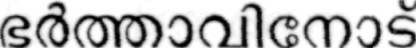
ഭര്‍ത്താവിനോട്
